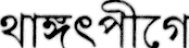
থাঙ্গৎপীগে
